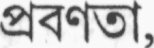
প্রবণতা,
